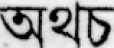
অথচ
